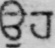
ਉਹ
